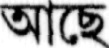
আছে
